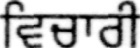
ਵਿਚਾਰੀ
